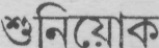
শুনিয়োক
